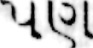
પણ
